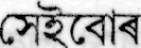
সেইবোৰ
